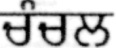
ਚੰਚਲ
